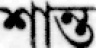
শান্ত
